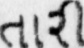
તારી
